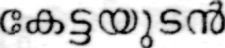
കേട്ടയുടന്‍
